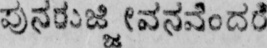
ಪುನರುಜ್ಜೀವನವೆಂದರೆ
